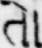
તો
